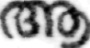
ആ
